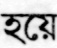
হয়ে
